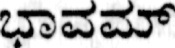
ಭಾವಮ್
